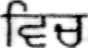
ਵਿਚ
